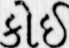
કોઈ
